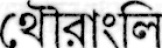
থৌরাংলি
